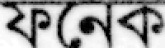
ফনেক
